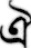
ঐ
